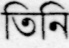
তিনি
